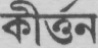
কীৰ্ত্তন
